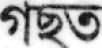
গছত
